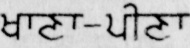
ਖਾਣਾ-ਪੀਣਾ
